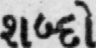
શબ્દો
